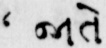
'જાતે
